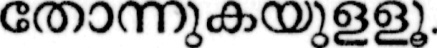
തോന്നുകയുള്ളൂ.
